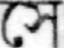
সে
